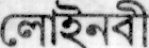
লোইনবী
